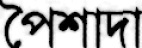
পৈশাদা
